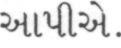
આપીએ.
